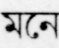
মনে
